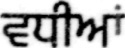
ਵਧੀਆਂ
